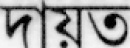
দায়ত
